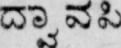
ದ್ವಾವಪಿ
